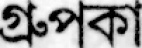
গ্রুপকা
